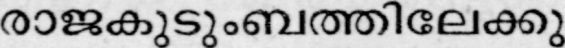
രാജകുടുംബത്തിലേക്കു
